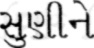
સુણીને
